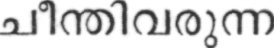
ചീന്തിവരുന്ന
